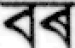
বৰ
